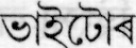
ভাইটোৰ
